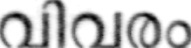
വിവരം
